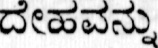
ದೇಹವನ್ನು
